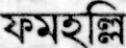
ফমহল্লি
